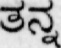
ತನ್ನ
